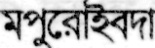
মপুরোইবদা
